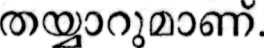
തയ്യാറുമാണ്.
